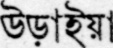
উড়াইয়া
